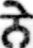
ਨੇ
